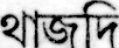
থাজদি
